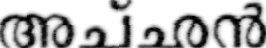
അച്ഛന്‍
